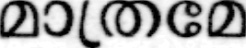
മാത്രമേ
